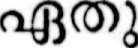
ഏതു
